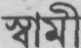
স্বামী
